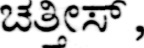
ಚತ್ತೀಸ್,
